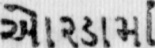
ઓરડામાં
